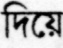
দিয়ে
